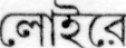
লোইরে
